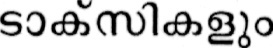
ടാക്സികളും
